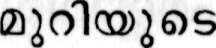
മുറിയുടെ
